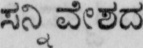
ಸನ್ನಿವೇಶದ
